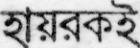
হায়রকই
